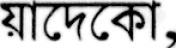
য়াদেকো,
